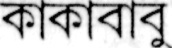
কাকাবাবু
